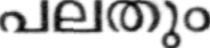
പലതും
